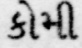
કોમી
